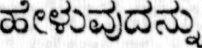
ಹೇಳುವುದನ್ನು
